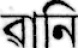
ৱানি
